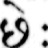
છેઃ
